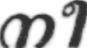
നീ
